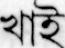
খাই
